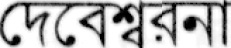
দেবেশ্বরনা
